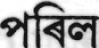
পৰিল
